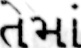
તેમાં
